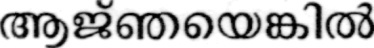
ആജ്ഞയെങ്കില്‍
